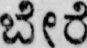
ಬೇರೆ
